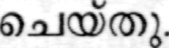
ചെയ്തു.
